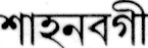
শাহনবগী
